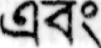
এবং
